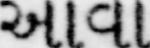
આવા
